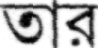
তার
